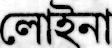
লোইনা
